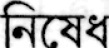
নিষেধ
